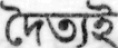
দৈত্যই
